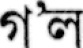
গ'ল
